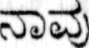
ನಾವು
